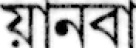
য়ানবা
